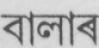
বালাৰ
